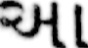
આ
